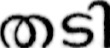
തടി
